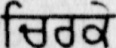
ਚਿਰਕੇ
